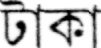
টাকা
